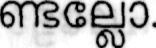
ണ്ടല്ലോ.
